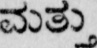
ಮತ್ತು
